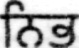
ਨਿਭ
